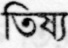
তিষ্য
